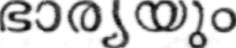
ഭാര്യയും
